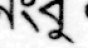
নংবু
